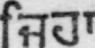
ਜਿਹਾ
